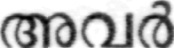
അവര്‍
